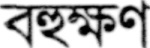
বহুক্ষণ
